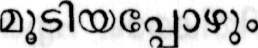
മൂടിയപ്പോഴും
